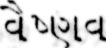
વૈષ્ણવ
